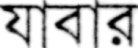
যাবার
